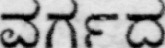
ವರ್ಗದ
